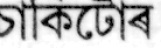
চাকিটোৰ
